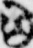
છે
